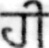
ਹੀ
